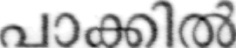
പാക്കില്‍
